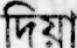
দিয়া
